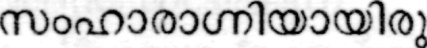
സംഹാരാഗ്നിയായിരു
